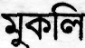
মুকলি
